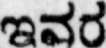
ಇವರ
